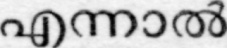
എന്നാല്‍
